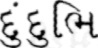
દુંદુભિ
